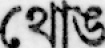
থোঙ
